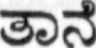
ತಾನೆ
